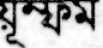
য়ূম্ফম
